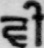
ਵੀ
